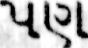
પણ
